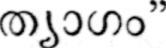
ത്യാഗം"
